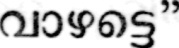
വാഴട്ടെ"
